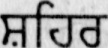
ਸ਼ਹਿਰ
